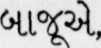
બાજૂએ,
